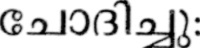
ചോദിച്ചു:
